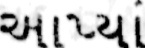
આપ્યાં
